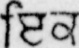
ਇਕ
